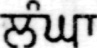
ਲੰਘਾ
